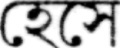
হেসে
